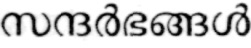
സന്ദര്‍ഭങ്ങള്‍
